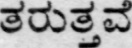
ತರುತ್ತವೆ
